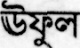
ঊফুল
